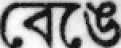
বেঙে
